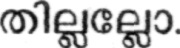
തില്ലല്ലോ.
